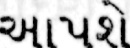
આપશે
